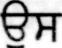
ਉਸ
